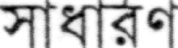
সাধারণ
